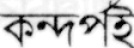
কন্দর্পই
